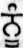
ਨੂੰ
